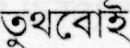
তুথবোই
